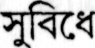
সুবিধে
